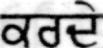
ਕਰਦੇ
